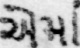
એમાં
